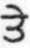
ਤੇ
